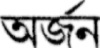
অর্জন
